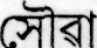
সৌৱা
